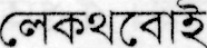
লেকথবোই
